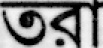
তরা
